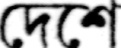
দেশে
